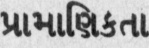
પ્રામાણિકતા
